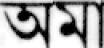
অমা
